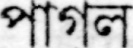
পাগল
